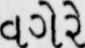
વગેરે
